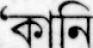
'কানি
